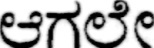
ಆಗಲೇ
